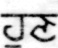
ਹੁਣ
